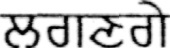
ਲਗਣਗੇ
